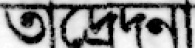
তাদ্রেদনা
